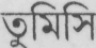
তুমিসি
